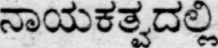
ನಾಯಕತ್ವದಲ್ಲಿ
